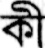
কী
